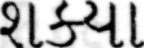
શક્યા
